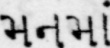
મનમાં
